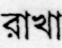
রাখা
